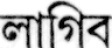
লাগিব
